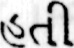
હતી
